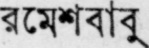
রমেশবাবু
